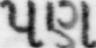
પણ
